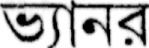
ভ্যানর
